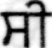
ਸੀ
